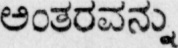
ಅಂತರವನ್ನು
